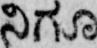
ನಿಗೂ
